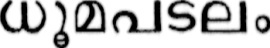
ധൂമപടലം
